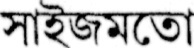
সাইজমতো
